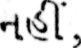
નહીં,
